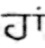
ਹਾਂ
